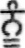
ਨੂੰ
